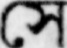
সে
